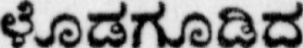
ಳೊಡಗೂಡಿದ
